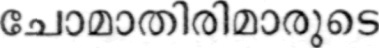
ചോമാതിരിമാരുടെ
